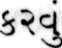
કરવું
